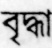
বৃদ্ধা
